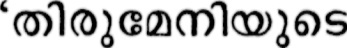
‘തിരുമേനിയുടെ
